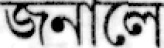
জনালে
